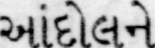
આંદોલને
